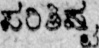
ಪರಿಶಿಷ್ಟ
